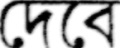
দেবে
